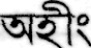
অহীং
